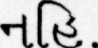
નહિ.
